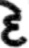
દે
